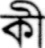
কী
